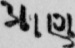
પ્રાણ
